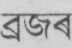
ব্ৰজৰ
